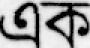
এক
